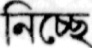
নিচ্ছে
